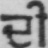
ਦੀ
